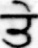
ਤੇ
